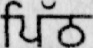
ਪਿੱਠ
